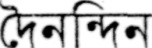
দৈনন্দিন
